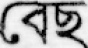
বেছ
